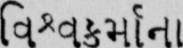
વિશ્વકર્માના
